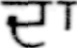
ਦਾ
